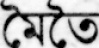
মৈতৈ
